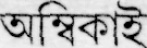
অম্বিকাই
